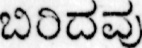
ಬಿರಿದವು
